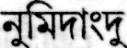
নুমিদাংদু
